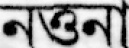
নত্তনা
